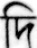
দি
